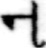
ન
